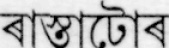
ৰাস্তাটোৰ
